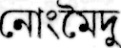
নোংমৈদু
